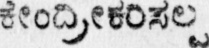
ಕೇಂದ್ರೀಕರಿಸಲ್ಪ
